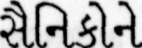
સૈનિકોને
